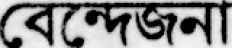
বেন্দেজনা
